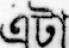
এটা
